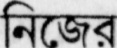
নিজের
